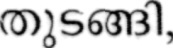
തുടങ്ങി,
